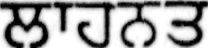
ਲਾਹਨਤ
